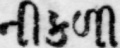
નીકળી
